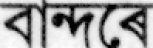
বান্দৰে
